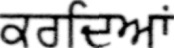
ਕਰਦਿਆਂ
